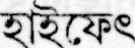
হাইফেৎ
